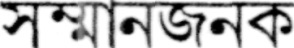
সম্মানজনক
